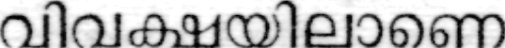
വിവക്ഷയിലാണെ
